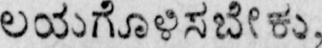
ಲಯಗೊಳಿಸಬೇಕು,
